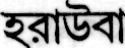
হরাউবা
